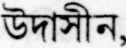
উদাসীন,
